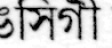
ঙসিগী
